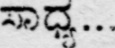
ಸಾಧ್ಯ...
